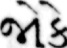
જોકે
